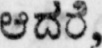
ಆದರೆ,
